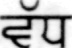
ਵੱਧ
